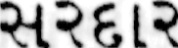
સરદાર
